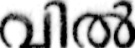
വില്‍
